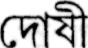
দোষী
